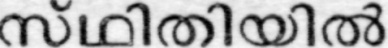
സ്ഥിതിയില്‍
